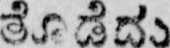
ತೊಡೆದು
